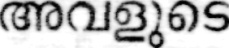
അവളുടെ
